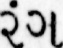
રંગ
